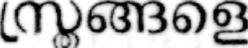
സ്ത്രങ്ങളെ
